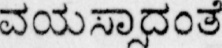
ವಯಸ್ಸಾದಂತೆ
